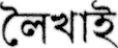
লৈখাই
